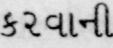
કરવાની
